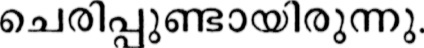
ചെരിപ്പുണ്ടായിരുന്നു.
